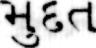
મુદત
